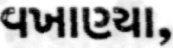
વખાણ્યા,
